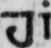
ਹਾਂ
